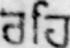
ਰਹਿ
